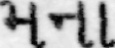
મના
